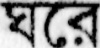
ঘরে
